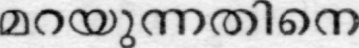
മറയുന്നതിനെ
